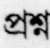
প্রশ্ন
